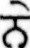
ਨੇ
